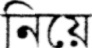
নিয়ে
